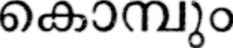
കൊമ്പും
